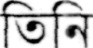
তিনি
